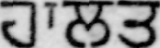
ਹਾਲਤ
